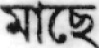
মাছে
